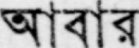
আবার
